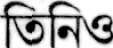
তিনিও
